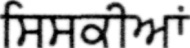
ਸਿਸਕੀਆਂ
